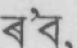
ৰ'ব,
